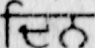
ਦਿਨ
